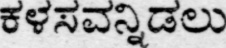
ಕಳಸವನ್ನಿಡಲು
